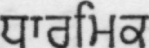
ਧਾਰਮਿਕ
